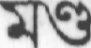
মণ্ড
